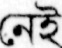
নেই
